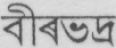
বীৰভদ্ৰ
